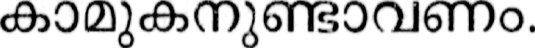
കാമുകനുണ്ടാവണം.
